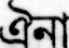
ঐনা
